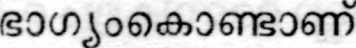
ഭാഗ്യംകൊണ്ടാണ്
